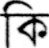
কি
